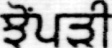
ਝੋਂਪੜੀ
